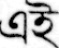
এই
